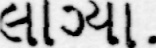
લાગ્યા.
